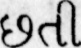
છતી
